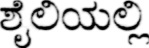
ಶೈಲಿಯಲ್ಲಿ
